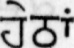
ਹੇਠਾਂ
